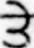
ਤੇ
